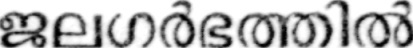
ജലഗര്‍ഭത്തില്‍
